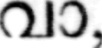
വാ,
